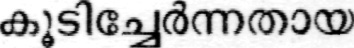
കൂടിച്ചേര്‍ന്നതായ
